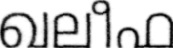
ഖലീഫ
